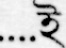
....ই
